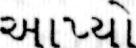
આપ્યો
